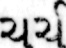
ચર્ચ
